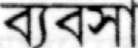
ব্যবসা
